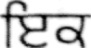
ਇਕ
